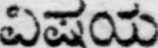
ವಿಷಯ
